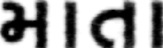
માતા
